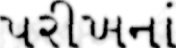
પરીખનાં
